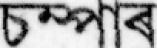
চম্পাৰ
